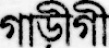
গাড়ীগী
